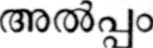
അല്‍പ്പം
